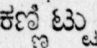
ಕಣ್ಣಿಟ್ಟು
